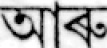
আৰু
